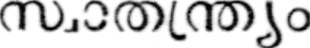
സ്വാതന്ത്ര്യം
